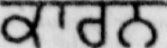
ਕਾਰਨ
